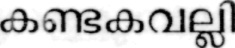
കണ്ടകവല്ലി
